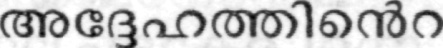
അദ്ദേഹത്തിന്റെ
